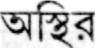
অস্থির
